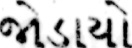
જોડાયો
